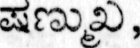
ಷಣ್ಮುಖ,
